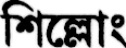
শিল্লোং
